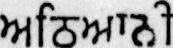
ਅਠਿਆਨੀ
